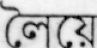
লৈয়ে
